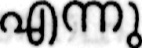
എന്നു
